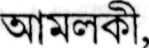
আমলকী,
